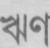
ঋণ
